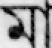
মা
